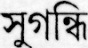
সুগন্ধি
